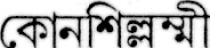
কোনশিল্লম্মী
